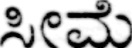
ಸೀಮೆ
